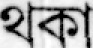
থকা
